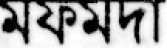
মফমদা
